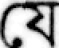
যে
